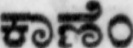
ಕಾಣೆಂ
